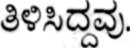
ತಿಳಿಸಿದ್ದವು.
